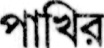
পাখির
